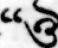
“ঔ
